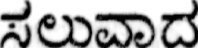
ಸಲುವಾದ
